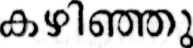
കഴിഞ്ഞു
